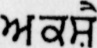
ਅਕਸ਼ੈ
